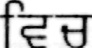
ਵਿਚ
